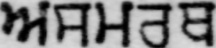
ਅਸਮਰਥ
